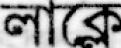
লাক্লে
